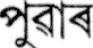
পুৱাৰ
